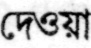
দেওয়া
